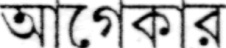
আগেকার
